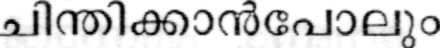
ചിന്തിക്കാന്‍പോലും
